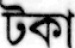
টকা
